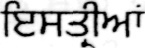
ਇਸਤ੍ਰੀਆਂ
